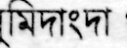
নুমিদাংদা
